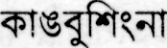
কাঙবুশিংনা
